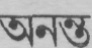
অনন্ত
